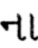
ના
